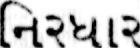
નિરધાર
